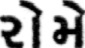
રોમે
